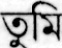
তুমি
